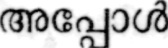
അപ്പോള്‍
